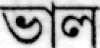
ভাল
